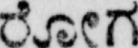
ರೋಗ
